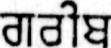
ਗਰੀਬ
